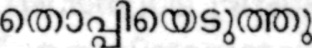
തൊപ്പിയെടുത്തു
